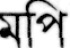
মপি
